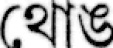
থোঙ
